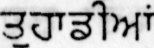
ਤੁਹਾਡੀਆਂ
